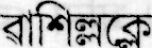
ৱাশিল্লক্লে
